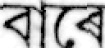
বাৰে
